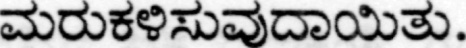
ಮರುಕಳಿಸುವುದಾಯಿತು.
